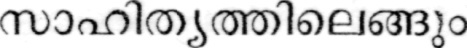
സാഹിത്യത്തിലെങ്ങും
